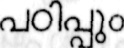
പഠിപ്പും
